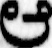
ಆ
